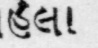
પહેલા
